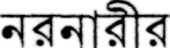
নরনারীর
